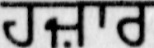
ਹਜ਼ਾਰ
